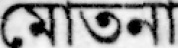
মোতনা
